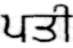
ਪਤੀ
